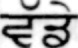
ਵੱਡੇ
